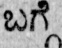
ಬಗ್ಗೆ
